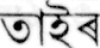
তাইৰ
